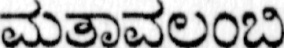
ಮತಾವಲಂಬಿ
